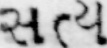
સત્ય
